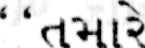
"તમારે
